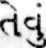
તેવું
